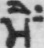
ਮੈਂ
